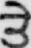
ਤੇ
